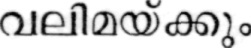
വലിമയ്ക്കും
